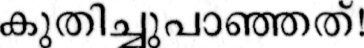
കുതിച്ചുപാഞ്ഞത്!
